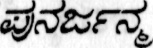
ಪುನರ್ಜನ್ಮ
